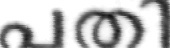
പതി
